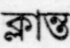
ক্লান্ত
